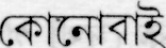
কোনোবাই
